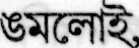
ঙমলোই,
